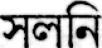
সলনি
